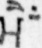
ਮੈਂ
